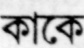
কাকে
